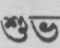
শুভ
